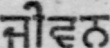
ਜੀਵਨ
